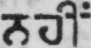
ਨਹੀਂ
